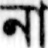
না
